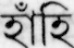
হাঁহি
